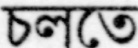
চলতে
